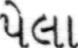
પેલા
